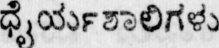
ಧೈರ್ಯಶಾಲಿಗಳು
